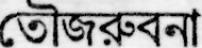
তৌজরুবনা
